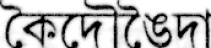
কৈদৌঙৈদা
